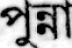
পুন্না
